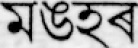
মঙহৰ
